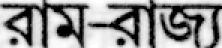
রাম-রাজ্য
